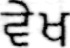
ਵੇਖ
